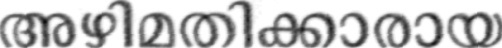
അഴിമതിക്കാരായ
